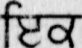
ਇਕ
